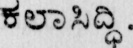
ಕಲಾಸಿದ್ಧಿ.
